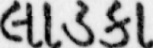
લાડકા
